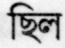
ছিল
